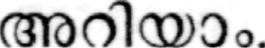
അറിയാം.
